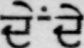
ਦੇਂਦੇ
